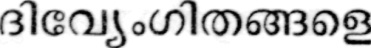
ദിവ്യേംഗിതങ്ങളെ
